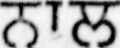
ਨਾਲ
